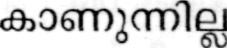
കാണുന്നില്ല
